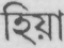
হিয়া
